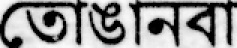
তোঙানবা
